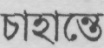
চাহান্তে
